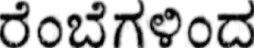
ರೆಂಬೆಗಳಿಂದ
